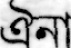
ঐনা
